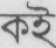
কই
